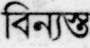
বিন্যস্ত
